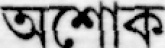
অশোক
